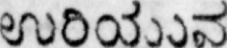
ಉರಿಯುವ
